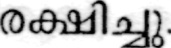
രക്ഷിച്ചു.
